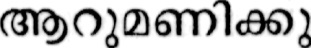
ആറുമണിക്കു
